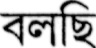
বলছি
